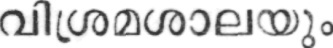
വിശ്രമശാലയും
